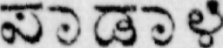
ಪಾಡಾಳಿ
